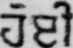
ਹੋਈ
